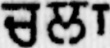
ਚਲਾ
